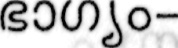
ഭാഗ്യം-
